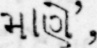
માણે',
